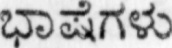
ಭಾಷೆಗಳು
